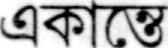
একান্তে
